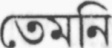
তেমনি
